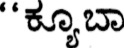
"ಕ್ಯೂಬಾ
